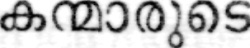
കന്മാരുടെ
